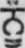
ਨੂੰ
